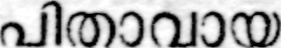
പിതാവായ
